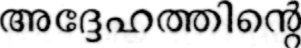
അദ്ദേഹത്തിന്റെ
